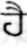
ਹੈ
